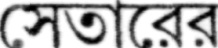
সেতারের
